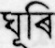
ঘূৰি
